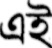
এই
